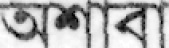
অশাবা
